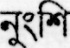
নুংশি
